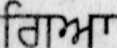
ਗਿਆ
